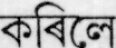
কৰিলে
